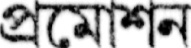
প্রমোশন
